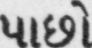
પાછો
